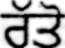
ਰੱਤੋ
